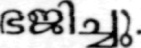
ഭജിച്ചു.
